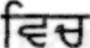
ਵਿਚ
